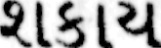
શકાય
